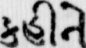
કહીને
